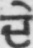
ਦੇ
